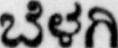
ಬೆಳಗಿ
